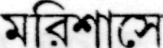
মরিশাসে
